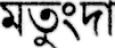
মতুংদা
